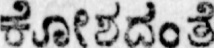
ಕೋಶದಂತೆ
